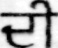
ਦੀ
